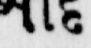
બાદ
